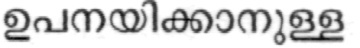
ഉപനയിക്കാനുള്ള
